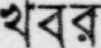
খবর
